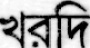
খরদি
